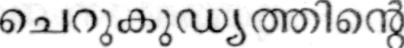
ചെറുകുഡ്യത്തിന്റെ
